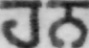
ਹਨ
